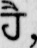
ਹੈ,
